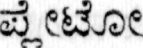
ಪ್ಲೇಟೋ
